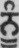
ਨੂੰ
